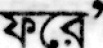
ফরে’
